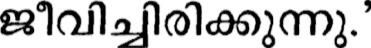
ജീവിച്ചിരിക്കുന്നു.’
